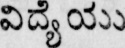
ವಿದ್ಯೆಯು
